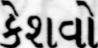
કેશવો
